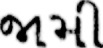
જામી
